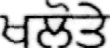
ਖਲੋਤੇ
